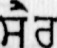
ਸੈਰ
